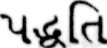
પદ્ધતિ
